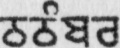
ਠਠੰਬਰ
